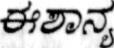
ಈಶಾನ್ಯ
